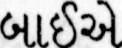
બાઈએ
